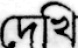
দেখি
